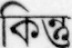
কিন্তু
